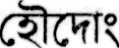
হৌদোং
